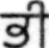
ਭੀ
